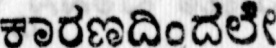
ಕಾರಣದಿಂದಲೇ
